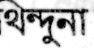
থিন্দুনা
